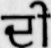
ਦੀ
